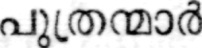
പുത്രന്മാര്‍
